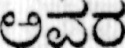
ಅವರ
